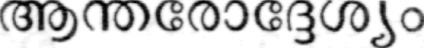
ആന്തരോദ്ദേശ്യം
